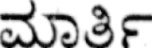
ಮಾರ್ತಿ
